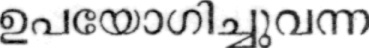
ഉപയോഗിച്ചുവന്ന
